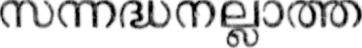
സന്നദ്ധനല്ലാത്ത
